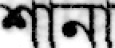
শানা
